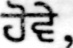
ਹੋਵੇ,
